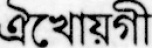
ঐখোয়গী
